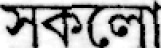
সকলো
